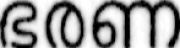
ഭരണ
